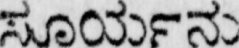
ಸೂರ್ಯನು
